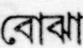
বোঝা
